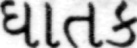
ઘાતક
